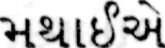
મથાઈએ
